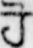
ਹੋ
